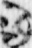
છે
